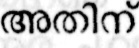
അതിന്
